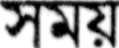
সময়
